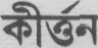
কীৰ্ত্তন
